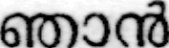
ഞാന്‍
